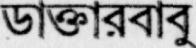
ডাক্তারবাবু
